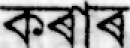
কৰাৰ
